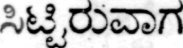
ಸಿಟ್ಟಿರುವಾಗ
